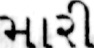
મારી
